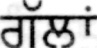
ਗੱਲਾਂ
